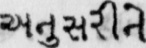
અનુસરીને
